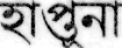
হাপ্তুনা
